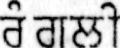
ਰੰਗਲੀ
